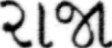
રાજા
